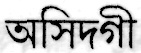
অসিদগী
